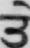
ਤੇ
